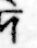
দি
